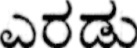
ಎರಡು
